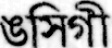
ঙসিগী
